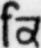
ਕਿ
